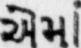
એમાં
